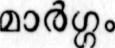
മാര്‍ഗ്ഗം
